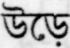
উড়ে
